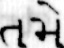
તમે
